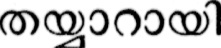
തയ്യാറായി
